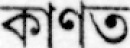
কাণত
